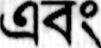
এবং
